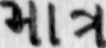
માત્ર
